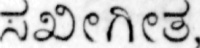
ಸಖೀಗೀತ,
